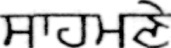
ਸਾਹਮਣੇ
